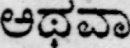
ಅಥವಾ
